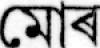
মোৰ
